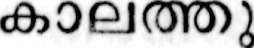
കാലത്തു
